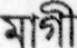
মাগী
